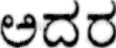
ಅದರ
